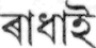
ৰাধাই
